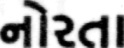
નોરતા
